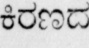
ಕಿರಣದ
